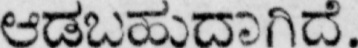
ಆಡಬಹುದಾಗಿದೆ.
